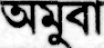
অমুবা
